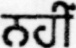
ਨਹੀਂ
